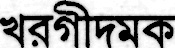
খরগীদমক
